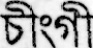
চীংগী
